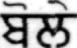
ਬੋਲੇ
